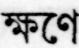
ক্ষণে
